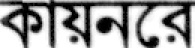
কায়নরে
